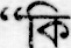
"কি
